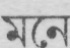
মনে
